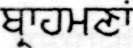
ਬ੍ਰਾਹਮਣਾਂ
